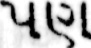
પણ
